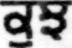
ਕੁਝ
